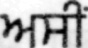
ਅਸੀਂ
